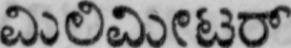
ಮಿಲಿಮೀಟರ್
